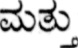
ಮತ್ತು
